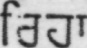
ਰਿਹਾ
